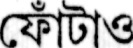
ফোঁটাও
